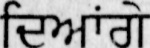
ਦਿਆਂਗੇ
